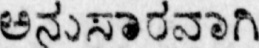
ಅನುಸಾರವಾಗಿ
